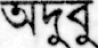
অদুবু
